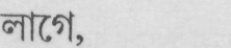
লাগে,
